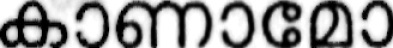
കാണാമോ
